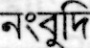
নংবুদি
